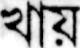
খায়
